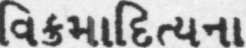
વિક્રમાદિત્યના
